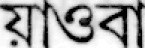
য়াওবা
